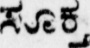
ಸೂಕ್ತ
